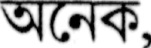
অনেক,
